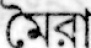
মৈরা
